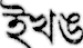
ইখঙ
